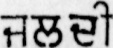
ਜਲਦੀ
